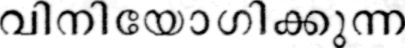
വിനിയോഗിക്കുന്ന
